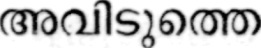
അവിടുത്തെ
